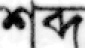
শব্দ
